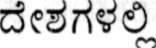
ದೇಶಗಳಲ್ಲಿ
